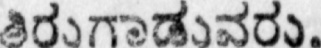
ತಿರುಗಾಡುವರು.
